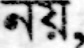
নয়,
